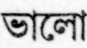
ভালো
